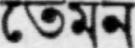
তেমন
